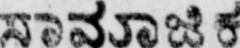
ಸಾಮಾಜಿಕ
